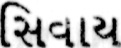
સિવાય
